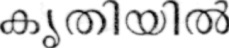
കൃതിയില്‍
